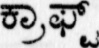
ಕ್ರಾಫ್ಟ್
